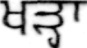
ਖੜ੍ਹਾ
